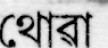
থোৱা
